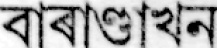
বাৰাণ্ডাখন
